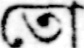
তো
